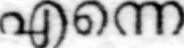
എന്നെ
